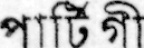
পার্টিগী
